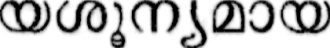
യശൂന്യമായ
